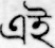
এই
